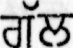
ਗੱਲ
